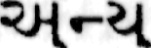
અન્ય
